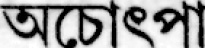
অচোৎপা
